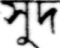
সুদ
